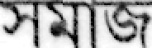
সমাজ
